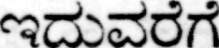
ಇದುವರೆಗೆ
